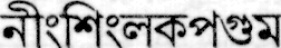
নীংশিংলকপগুম
